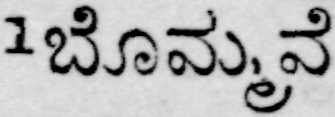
1ಬೊಮ್ಮವೆ
